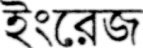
ইংরেজ
